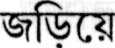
জড়িয়ে
